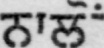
ਨਾਲੋਂ
